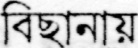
বিছানায়
